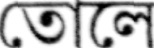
তোলে
